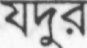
যদুর
